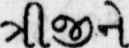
ત્રીજીને
